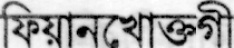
ফিয়ানখোক্তগী
